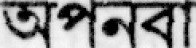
অপনবা
